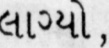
લાગ્યો,
